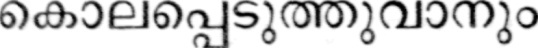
കൊലപ്പെടുത്തുവാനും
